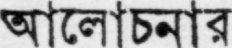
আলোচনার
